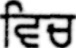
ਵਿਚ
